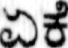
ಏಕೆ
